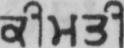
ਕੀਮਤੀ
